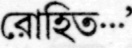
রোহিত...’
